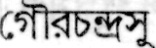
গৌরচন্দ্রসু
